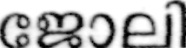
ജോലി
